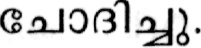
ചോദിച്ചു.
